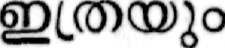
ഇത്രയും
